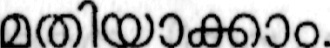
മതിയാക്കാം.
